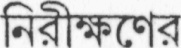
নিরীক্ষণের
